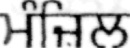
ਮੰਜ਼ਿਲ
